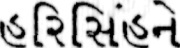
હરિસિંહને
